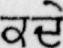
ਕਦੇ
